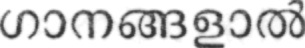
ഗാനങ്ങളാല്‍
